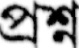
প্রশ্ন
